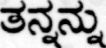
ತನ್ನನ್ನು
